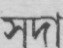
সদা
